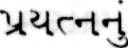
પ્રયત્નનું
